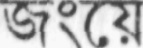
জংয়ে
